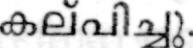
കല്പിച്ചു.
